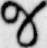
જ
